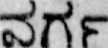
ವರ್ಗ
